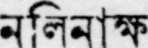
নলিনাক্ষ
